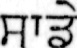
ਸਾਡੇ
